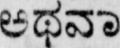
ಅಥವಾ
